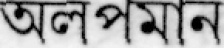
অলপমান
